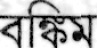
বঙ্কিম
